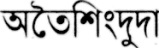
অতৈশিংদুদা
